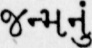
જન્મનું
